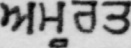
ਅਮੂਰਤ
